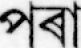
পৰা
